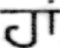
ਹਾਂ
